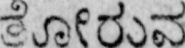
ತೋರುವ
